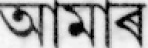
আমাৰ
